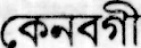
কেনবগী
